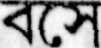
বসে
